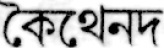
কৈথেনদ
